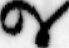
જ
